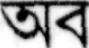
অব
